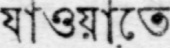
যাওয়াতে
